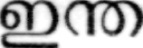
ഇന്ത
